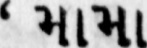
'મામા
